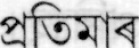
প্রতিমাৰ
